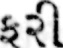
ફરી
